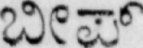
ಬೀಪ್
